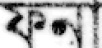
ফনা
